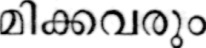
മിക്കവരും
